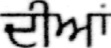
ਦੀਆਂ
